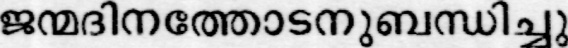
ജന്മദിനത്തോടനുബന്ധിച്ചു
